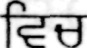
ਵਿਚ
